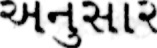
અનુસાર
